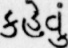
કહેવું
